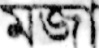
মজা
